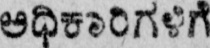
ಅಧಿಕಾರಿಗಳಿಗೆ
